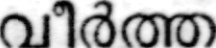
വീര്‍ത്ത
